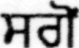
ਸਗੋਂ
